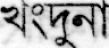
খংদুনা
